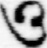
ও
